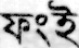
ফংই
